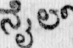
ನೈಲ್
